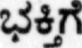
ಭಕ್ತಿಗೆ
